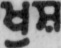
ਖੁਸ਼
